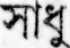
সাধু
